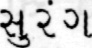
સુરંગ
